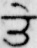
ਤੇ
